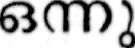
ഒന്നു
